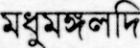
মধুমঙ্গলদি
